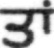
ਤਾਂ
